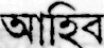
আহিব
